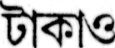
টাকাও
